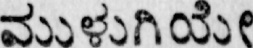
ಮುಳುಗಿಯೇ
